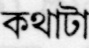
কথাটা
